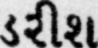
ડરીશ
